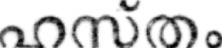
ഹസ്തം
